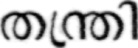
തന്ത്രി
